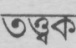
তত্ত্বক
